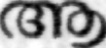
ആ
